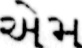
એમ
